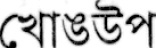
খোঙউপ
